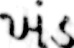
ખંડ
